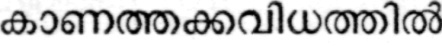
കാണത്തക്കവിധത്തില്‍
